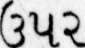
ઉપર
